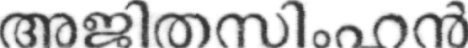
അജിതസിംഹന്‍
